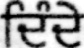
ਦਿੰਦੇ
